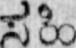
ಸಹಿ
